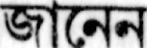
জানেন
